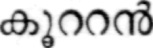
കൂററന്‍
